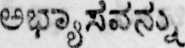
ಅಭ್ಯಾಸವನ್ನು
